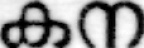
കന
